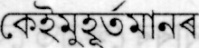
কেইমুহূর্তমানৰ
